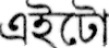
এইটো
